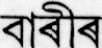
বাৰীৰ
